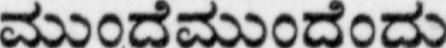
ಮುಂದೆಮುಂದೆಂದು
